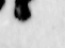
જ
